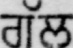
ਗੱਲ
